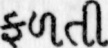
ફળતી
